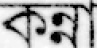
কন্না
